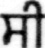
ਸੀ
